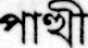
পাত্থী
